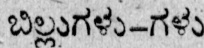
ಬಿಲ್ಲುಗಳು-ಗಳು
